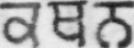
ਕਥਨ
